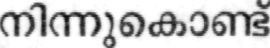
നിന്നുകൊണ്ട്
